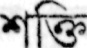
শক্তি
